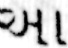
આ
